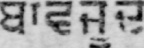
ਬਾਵਜੂਦ
